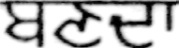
ਬਣਦਾ
